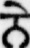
ਨੇ
